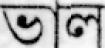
ভাল
